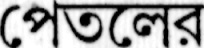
পেতলের
